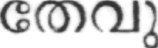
തേവു
